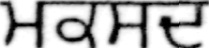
ਮਕਸਦ
